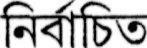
নির্বাচিত
